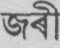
জৰী
